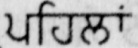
ਪਹਿਲਾਂ
